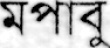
মপাবু
